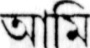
আমি
